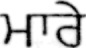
ਮਾਰੇ
